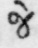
જે
